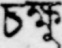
চক্ষু
